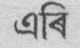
এৰি
